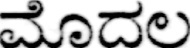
ಮೊದಲ
